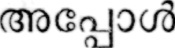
അപ്പോള്‍
